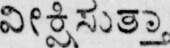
ವೀಕ್ಷಿಸುತ್ತಾ
